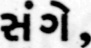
સંગે,
